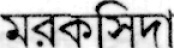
মরকসিদা
